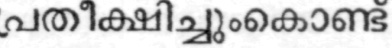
പ്രതീക്ഷിച്ചുംകൊണ്ട്
